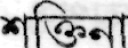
শক্তিনা
